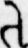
તે
